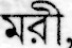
মরী,
